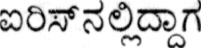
ಐರಿಸ್ನಲ್ಲಿದ್ದಾಗ
